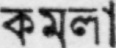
কমলা
